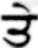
ਤੇ
